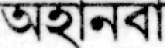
অহানবাল
